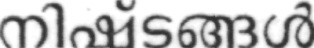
നിഷ്ടങ്ങള്‍
